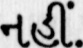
નહીં.
